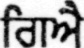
ਗਿਐ
